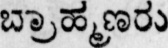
ಬ್ರಾಹ್ಮಣರು
